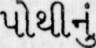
પોથીનું
